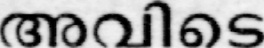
അവിടെ
